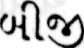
બીજી
